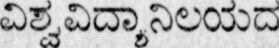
ವಿಶ್ವವಿದ್ಯಾನಿಲಯದ
